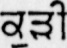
ਕੁੜੀ
